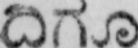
ದಿಗೂ
